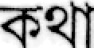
কথা
